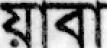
য়াবা
